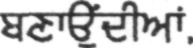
ਬਣਾਉਂਦੀਆਂ,
